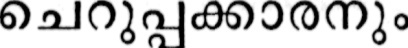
ചെറുപ്പക്കാരനും
